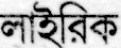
লাইরিক
